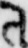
,તે
